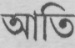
আতি
